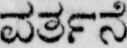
ವರ್ತನೆ
